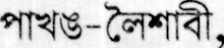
পাখঙ-লৈশাবী,
